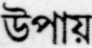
উপায়
